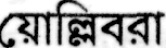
য়োল্লিবরা
